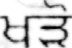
ਖੜੋ
